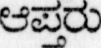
ಆಪ್ತರು
